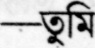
–তুমি
